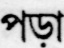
পড়া
